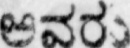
ಅವರು
